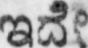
ಇದೇ
